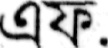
এফ.
